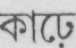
কাঢ়ে
